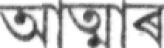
আত্মাৰ
